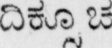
ದಿಕ್ಸೂಚ
